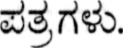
ಪತ್ರಗಳು.
